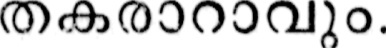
തകരാറാവും.
